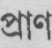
প্ৰাণ
